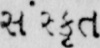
સંસ્કૃત
